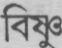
বিষ্ণু
